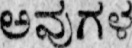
ಅವುಗಳ
